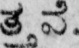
ತ್ತವೆ.
